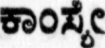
ಕಾಂಸ್ಯೇ
